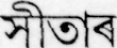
সীতাৰ
